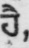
ਹੈ,
